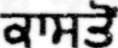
ਕਾਸਤੋ
